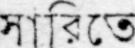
সারিতে
